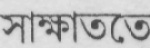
সাক্ষাততে
